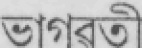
ভাগৱতী
